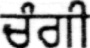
ਚੰਗੀ
